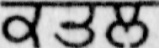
ਕਤਲ
